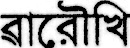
ৱারৌখি
